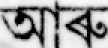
আৰু
